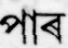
পাৰ
